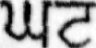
ਘਟ
